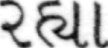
રહ્યા
